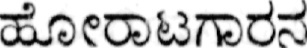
ಹೋರಾಟಗಾರನ
